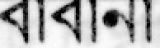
বাবানা
